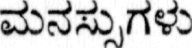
ಮನಸ್ಸುಗಳು
